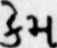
કેમ
